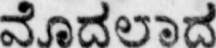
ಮೊದಲಾದ
